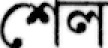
শেল
